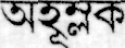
অহূম্লক
